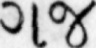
ગજ
